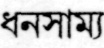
ধনসাম্য
